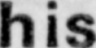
his
